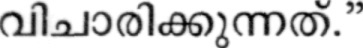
വിചാരിക്കുന്നത്."
